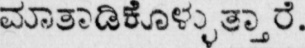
ಮಾತಾಡಿಕೊಳ್ಳುತ್ತಾರೆ.
